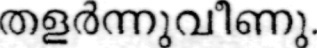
തളര്‍ന്നുവീണു.
